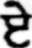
ਏ
